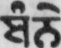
ਬੰਨੇ
